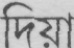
দিয়া
